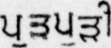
ਪੁੜਪੁੜੀ
